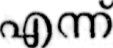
എന്ന്
